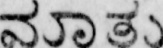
ಮಾತು
